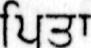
ਪਿਤਾ
